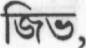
জিভ,
